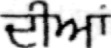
ਦੀਆਂ
